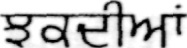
ਝਕਦੀਆਂ
